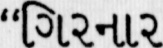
"ગિરનાર
